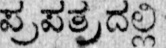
ಪ್ರಪತ್ರದಲ್ಲಿ
